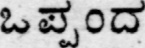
ಒಪ್ಪಂದ
